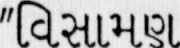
"વિસામણ
